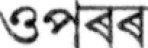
ওপৰৰ
